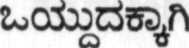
ಒಯ್ದುದಕ್ಕಾಗಿ
